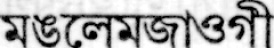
মঙলেমজাওগী
